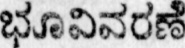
ಭೂವಿವರಣೆ
